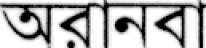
অরানবা
